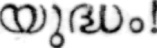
യുദ്ധം!
